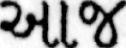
આજ
